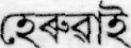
হেৰুৱাই
